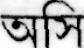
অসি
